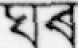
ঘৰ
